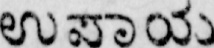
ಉಪಾಯ
